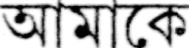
আমাকে
